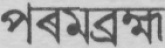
পৰমব্ৰহ্ম
